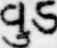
વુડ
